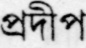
প্রদীপ
